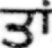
ਤਾਂ
